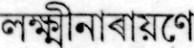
লক্ষ্মীনাৰায়ণে
